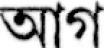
আগ
